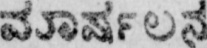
ಮಾರ್ಷಲನ
